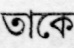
তাকে
